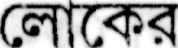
লোকের
